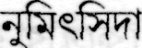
নুমিৎসিদা
